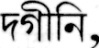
দগীনি,
